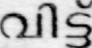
വിട്ട്
